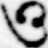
ও
